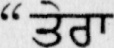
''ਤੇਰਾ
